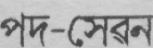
পদ-সেৱন
